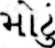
મોટું
